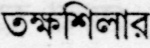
তক্ষশিলার
